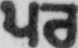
ਪਰ
